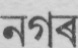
নগৰ
